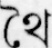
থৈ
